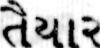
તૈયાર
